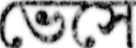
ভেসে
